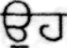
ਉਹ
